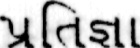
પ્રતિજ્ઞા
